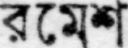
রমেশ
